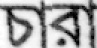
চারা
